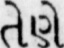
તેણે
